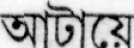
আটায়ে
